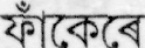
ফাঁকেৰে
